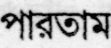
পারতাম
